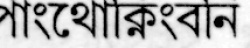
পাংথোক্নিংবনি
